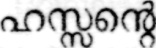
ഹസ്സന്റെ
